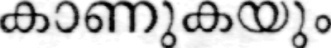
കാണുകയും
